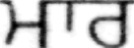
ਮਾਰ
